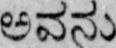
ಅವನು
